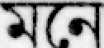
মনে
